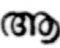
ആ
